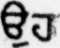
ਉਹ
